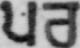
ਪਰ
